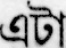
এটা
